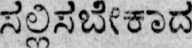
ಸಲ್ಲಿಸಬೇಕಾದ
